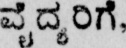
ವೈದ್ಯರಿಗೆ,
